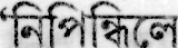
'নিপিন্ধিলে
